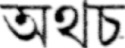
অথচ
